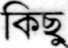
কিছু
